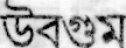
উবগুম
